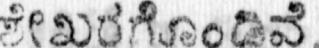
ಶೇಖರಗೊಂಡಿವೆ.
